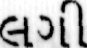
લગી
